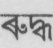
ৰুদ্ধ
